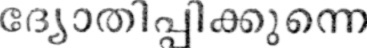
ദ്യോതിപ്പിക്കുന്നെ
